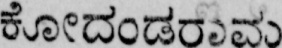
ಕೋದಂಡರಾಮ
